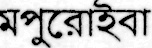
মপুরোইবা
